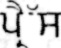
ਪ੍ਰੈੱਸ
